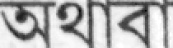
অথাবা
